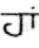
ਹਾਂ
